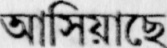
আসিয়াছে
